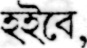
হইবে,
